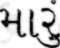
મારું
